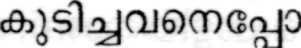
കുടിച്ചവനെപ്പോ
